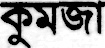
কুমজা
